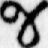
જ
